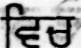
ਵਿਚ
